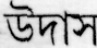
উদাস
